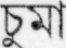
চুমা
